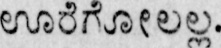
ಊರೆಗೋಲಲ್ಲ.
